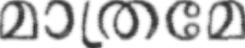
മാത്രമേ
